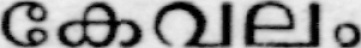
കേവലം
